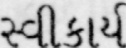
સ્વીકાર્ય
